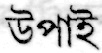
উপাই
